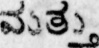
ಮತ್ತು
